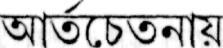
আর্তচেতনায়
